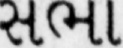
સભા
